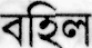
বহিল
